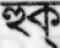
হুক্
